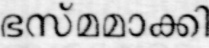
ഭസ്മമാക്കി
